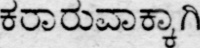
ಕರಾರುವಾಕ್ಕಾಗಿ
